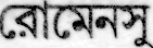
রোমেনসু
